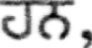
ਹਨ,
